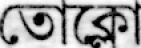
তোক্লে
